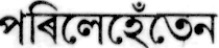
পৰিলেহেঁতেন
